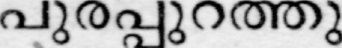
പുരപ്പുറത്തു
